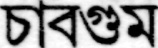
চাবগুম
